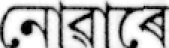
নোৱাৰে
